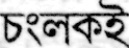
চংলকই
